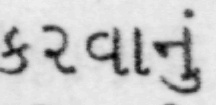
કરવાનું
